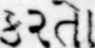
કરતો
